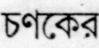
চণকের
